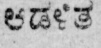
ಆಡಳಿತ
